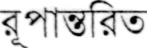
রূপান্তরিত
